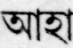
আহা
